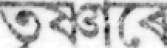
তৃষ্ণাৰে
